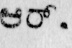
ಆರ್.
